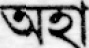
অহা
